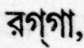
রগ্গা,
